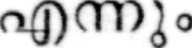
എന്നും
